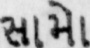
સામો
